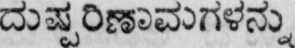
ದುಷ್ಪರಿಣಾಮಗಳನ್ನು
